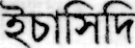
ইচাসিদি
